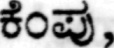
ಕೆಂಪು,
